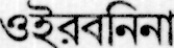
ওইরবনিনা
